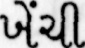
ખેંચી
